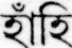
হাঁহি
